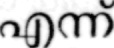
എന്ന്
